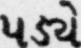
પડ્યે
